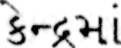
કેન્દ્રમાં
